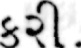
કરી.
